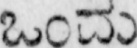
ಒಂದು
